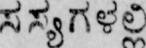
ಸಸ್ಯಗಳಲ್ಲಿ
